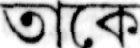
তাকে
